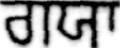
ਗਯਾ
